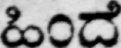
ಹಿಂದೆ
